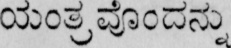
ಯಂತ್ರವೊಂದನ್ನು
